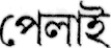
পেলাই
